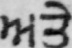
ਅਤੇ
